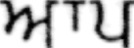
ਆਪ
